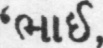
'ભાઈ,
